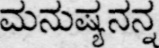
ಮನುಷ್ಯನನ್ನ
